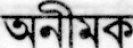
অনীমক
